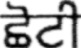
ਛੋਟੀ
